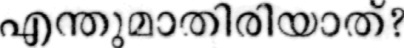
എന്തുമാതിരിയാത്?
